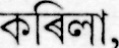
কৰিলা,
